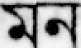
মন
